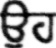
ਉਹ
